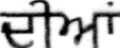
ਦੀਆਂ
